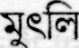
মুৎলি
